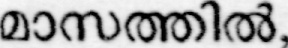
മാസത്തില്‍,
